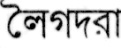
লৈগদরা
